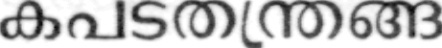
കപടതന്ത്രങ്ങ
